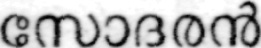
സോദരന്‍
